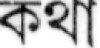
কথা
